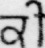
ਕੀ
